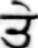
ਤੇ
